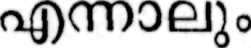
എന്നാലും
